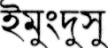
ইমুংদুসু
